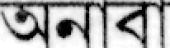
অনাবা
